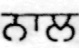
ਨਾਲ
